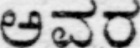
ಅವರ
